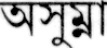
অসুম্না
